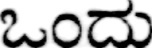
ಒಂದು
